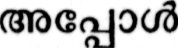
അപ്പോള്‍
